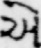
એ
